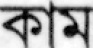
কাম
